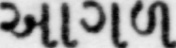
આગળ
